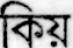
কিয়
